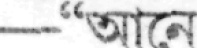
-"আনে
